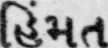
હિંમત
